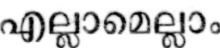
എല്ലാമെല്ലാം
